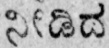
ನೀಡಿದ
